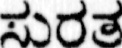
ಸುರತ
